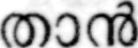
താന്‍
